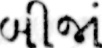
બીજાં
